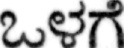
ಒಳಗೆ
